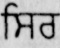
ਸਿਰ
